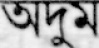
অদুম
